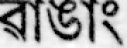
ৱাঙাং
